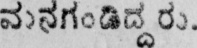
ಮನಗಂಡಿದ್ದರು.
